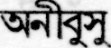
অনীবুসু
